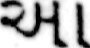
આ
